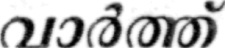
വാര്‍ത്ത്
